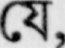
যে,
